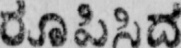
ರೂಪಿಸಿದ
